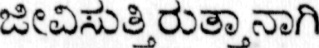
ಜೀವಿಸುತ್ತಿರುತ್ತಾನಾಗಿ
